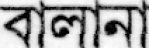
বালানা
